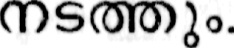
നടത്തും.
